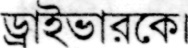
ড্রাইভারকে।
